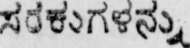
ಸರಕುಗಳನ್ನು
